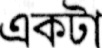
একটা
